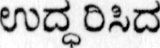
ಉದ್ಧರಿಸಿದ
